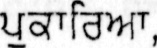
ਪੁਕਾਰਿਆ,
